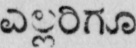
ಎಲ್ಲರಿಗೂ
